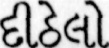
દીઠેલો
